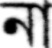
না
